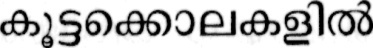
കൂട്ടക്കൊലകളില്‍
